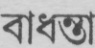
বাধন্তা
